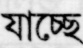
যাচ্ছে
